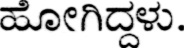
ಹೋಗಿದ್ದಳು.
